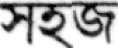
সহজ
